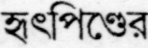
হৃত্পিণ্ডের
